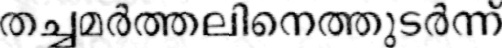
തച്ചമര്‍ത്തലിനെത്തുടര്‍ന്ന്
